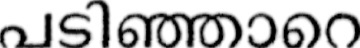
പടിഞ്ഞാറെ
